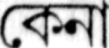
কেনা
